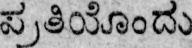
ಪ್ರತಿಯೊಂದು
